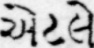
એટલે
